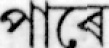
পাৰে
